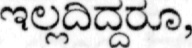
ಇಲ್ಲದಿದ್ದರೂ,
